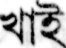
খাই
